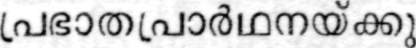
പ്രഭാതപ്രാര്‍ഥനയ്ക്കു
